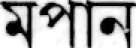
মপান
